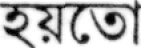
হয়তো
